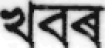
খবৰ
